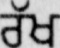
ਰੱਖ
